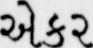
એકર
